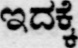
ಇದಕ್ಕೆ
